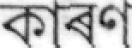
কাৰণ
